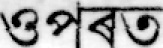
ওপৰত
